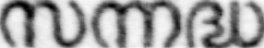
സന്നദ്ധ
